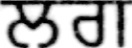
ਲਗ
